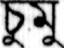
চুমু
